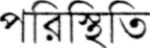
পরিস্থিতি
